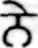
ਨੇ
